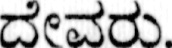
ದೇವರು.
